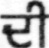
ਦੀ
